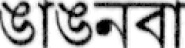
ঙাঙনবা
